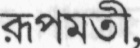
রূপমতী,
